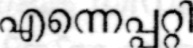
എന്നെപ്പറ്റി
